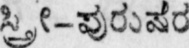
ಸ್ತ್ರೀ-ಪುರುಷರ
